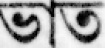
ভাত
